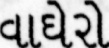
વાઘેરો
